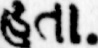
હતા.
